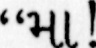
"મા!
